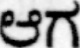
ಆಗ
